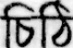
চিঠি
